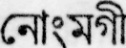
নোংমগী
